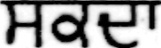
ਸਕਦਾ
